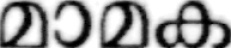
മാമക
